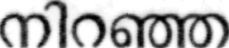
നിറഞ്ഞ
